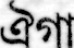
ঐগা
